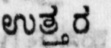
ಉತ್ತರ
